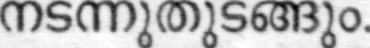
നടന്നുതുടങ്ങും.
